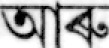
আৰু
